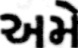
અમે
